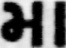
મા
